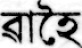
ৱাহৈ
